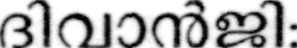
ദിവാന്‍ജി:
